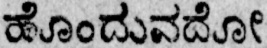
ಹೊಂದುವದೋ
